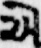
એ
